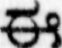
ಈ
